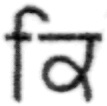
ਕਿ
